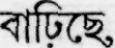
বাঢ়িছে,
